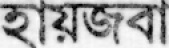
হায়জবা
